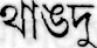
থাঙদু
